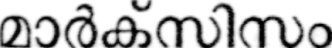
മാര്‍ക്സിസം
